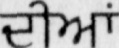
ਦੀਆਂ
